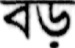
বড়
